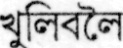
খুলিবলৈ
